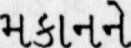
મકાનને
